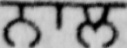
ਨਾਲ
